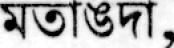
মতাঙদা,
